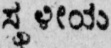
ಸ್ಥಳೀಯ
